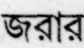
জরার
